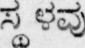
ಸ್ಥಳವು
